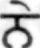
ਨੇ
